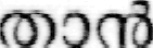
താന്‍
